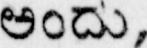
ಅಂದು,
